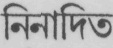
নিনাদিত
